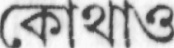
কোথাও
